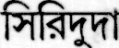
সিরিদুদা
